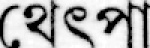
থেৎপা
